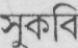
সুকবি
